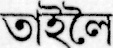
তাইলৈ
